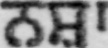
ਨਸ਼ਾ
